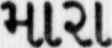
મારા
